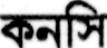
কনসি
